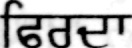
ਫਿਰਦਾ
